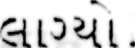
લાગ્યો.
